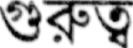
গুরুত্ব
